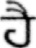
ਹੈ
